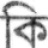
কি
